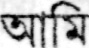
আমি
